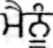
ਮੈਨੂੰ
